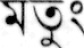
মতুং
